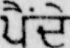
ਪੈਂਦੇ
